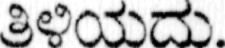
ತಿಳಿಯದು.
